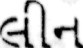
લીન
